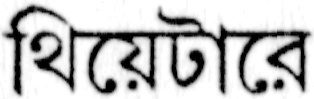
থিয়েটারে
